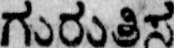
ಗುರುತಿಸ
